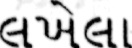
લખેલા
